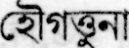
হৌগত্তুনা
